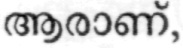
ആരാണ്,
